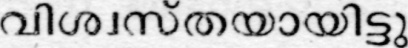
വിശ്വസ്തയായിട്ടു
